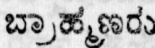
ಬ್ರಾಹ್ಮಣರು
